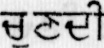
ਚੁਣਦੀ
